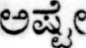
ಅಷ್ಟೇ
